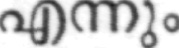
എന്നും
